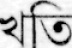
খতি
